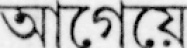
আগেয়ে
